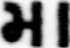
મા
